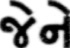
જેને
